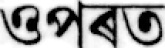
ওপৰত
